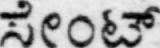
ಸೇಂಟ್
